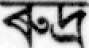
ৰুদ্ৰ
